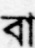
বা
